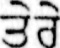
ਤੇਰੇ
